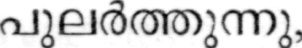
പുലര്‍ത്തുന്നു,
